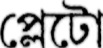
প্লেটো
